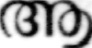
ആ
